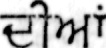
ਦੀਆਂ
